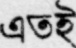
এতই
